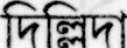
দিল্লীদা
